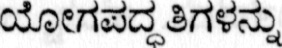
ಯೋಗಪದ್ಧತಿಗಳನ್ನು
